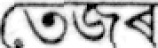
তেজৰ
